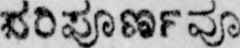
ಪರಿಪೂರ್ಣವೂ
